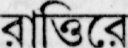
রাত্তিরে
